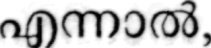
എന്നാല്‍,
